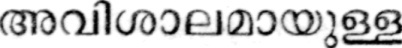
അവിശാലമായുള്ള
